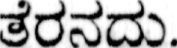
ತೆರನದು.
